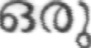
ഒരു
